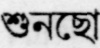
শুনছো
